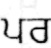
ਪਰ
